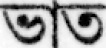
ভাত
